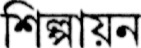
শিল্পায়ন
